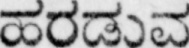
ಹರಡುವ
